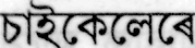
চাইকেলেৰে
